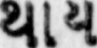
થાય
